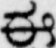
ಈ
